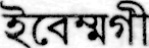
ইবেম্মগী
